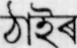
ঠাইৰ
